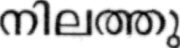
നിലത്തു
